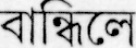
বান্ধিলে
